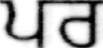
ਪਰ
